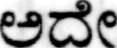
ಅದೇ
